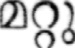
മറ്റു
